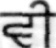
ਵੀ
